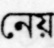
নেয়
